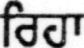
ਰਿਹਾ
